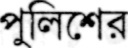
পুলিশের
